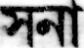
সনা
